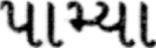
પામ્યા
